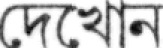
দেখোন
